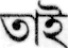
তাই
